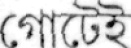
গোটেই
